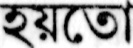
হয়তো
